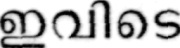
ഇവിടെ
